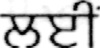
ਲਈਂ
